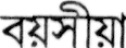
বয়সীয়া
